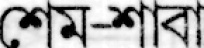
শেম-শাবা
